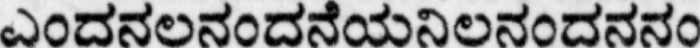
ಎಂದನಲನಂದನೆಯನಿಲನಂದನನಂ
